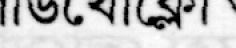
পাঙথোক্লো
